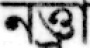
নত্ত্রা
